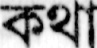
কথা
